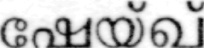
ഷേയ്ഖ്
